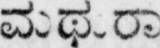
ಮಥುರಾ
